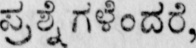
ಪ್ರಶ್ನೆಗಳೆಂದರೆ,
